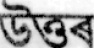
উত্তৰ
